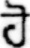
ਹੋ
